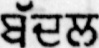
ਬੱਦਲ
